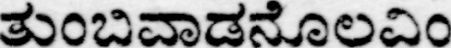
ತುಂಬಿವಾಡನೊಲವಿಂ
